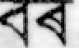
বৰ
